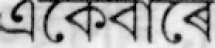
একেবাৰে
